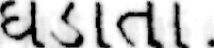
ઘડાતા.
